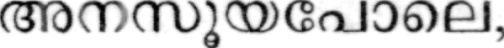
അനസൂയപോലെ,
